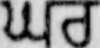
ਘਰ
